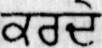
ਕਰਦੇ
